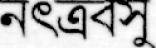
নৎত্রবসু
